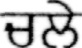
ਚਲੇ
